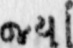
જ્યાં
